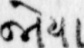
જોયા
